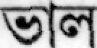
ভাল
